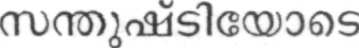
സന്തുഷ്ടിയോടെ
